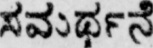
ಸಮರ್ಥನೆ
